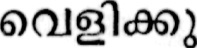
വെളിക്കു
